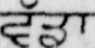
ਵੱਡਾ
